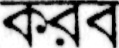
করব
